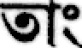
তাং
